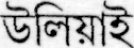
উলিয়াই
